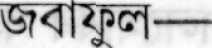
জবাফুল-
